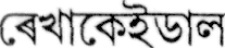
ৰেখাকেইডাল
